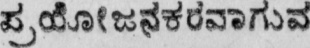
ಪ್ರಯೋಜನಕರವಾಗುವ
